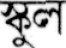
স্কুল
